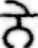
ਨੇ
